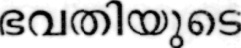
ഭവതിയുടെ
